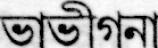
ভাভীগনা
